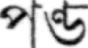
পণ্ড
